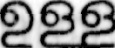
ഉള്ള
